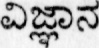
ವಿಜ್ಞಾನ
